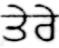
ਤੇਰੇ
